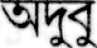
অদুবু
